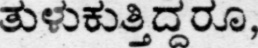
ತುಳುಕುತ್ತಿದ್ದರೂ,
